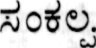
ಸಂಕಲ್ಪ.
